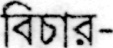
বিচার-
